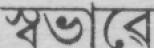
স্বভাৱে
